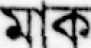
মাক
